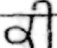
ਕੀ
